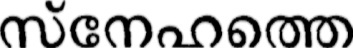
സ്നേഹത്തെ
